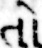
તો
